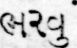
ભરવું
